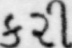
કરી
